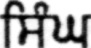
ਸਿੰਘ
